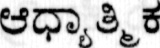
ಆಧ್ಯಾತ್ಮಿಕ
